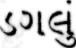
ડગલું
